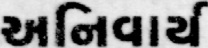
અનિવાર્ય
